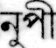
নুপী
